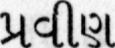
પ્રવીણ
